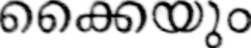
ക്കൈയും
